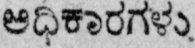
ಅಧಿಕಾರಗಳು
